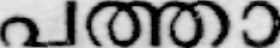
പത്താ
